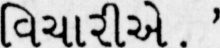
વિચારીએ.'
